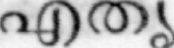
എതൃ
